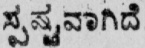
ಸ್ಪಷ್ಟವಾಗಿದೆ.
